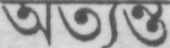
অত্যন্ত
